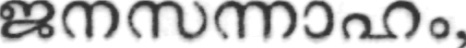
ജനസന്നാഹം,
